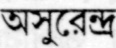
অসুরেন্দ্র
